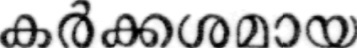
കര്‍ക്കശമായ
